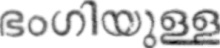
ഭംഗിയുള്ള
